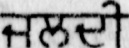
ਜਲਦੀ
